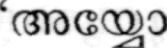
'അയ്യോ
